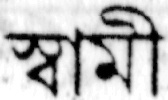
স্বামী
